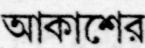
আকাশের
